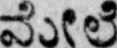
ಮೇಲೆ
